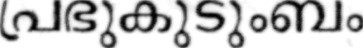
പ്രഭുകുടുംബം
